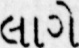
લાગે
